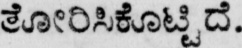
ತೋರಿಸಿಕೊಟ್ಟಿದೆ.
